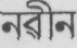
নৱীন
